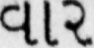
વાર
